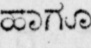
ಹಾಗೂ
